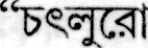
“চৎলুরো
